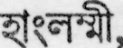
হাংলম্মী,
